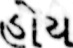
હોય
